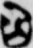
છે
